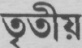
তৃতীয়
